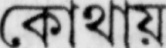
কোথায়
